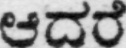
ಆದರೆ
